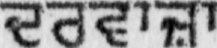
ਦਰਵਾਜ਼ਾ
